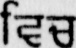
ਵਿਚ
